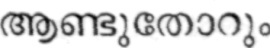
ആണ്ടുതോറും
